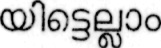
യിട്ടെല്ലാം
